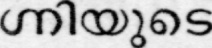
ഗ്നിയുടെ
